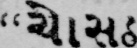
“ચોસઠ
